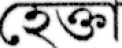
হেক্তা
